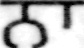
ਨਾ
